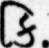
કિ.
